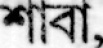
শাবা,
